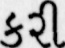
કરી
